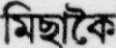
মিছাকৈ
